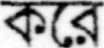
করে
